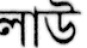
লাউ
